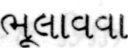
ભૂલાવવા
